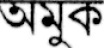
অমুক
